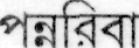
পন্নরিবা
